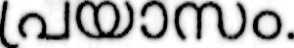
പ്രയാസം.
